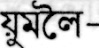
য়ুমলৈ-
